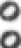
ঃ
